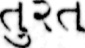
તુરત
